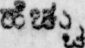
ಹೆಚ್ಚು
